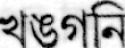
খঙগনি
